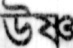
উষ্ণ
